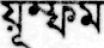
য়ূম্ফম
